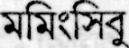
মমিংসিবু
